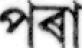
পৰা
